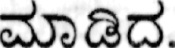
ಮಾಡಿದ.
